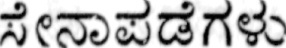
ಸೇನಾಪಡೆಗಳು
